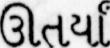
ઊતર્યાં
